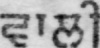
ਵਾਲੀ
